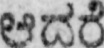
ಆದರೆ
